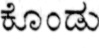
ಕೊಂಡು
